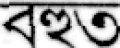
বহুত
